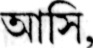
আসি,
